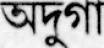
অদুগা
